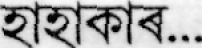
হাহাকাৰ...
